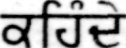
ਕਹਿੰਦੇ
